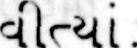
વીત્યાં.
